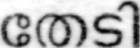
തേടി
